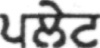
ਪਲੇਟ
